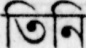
তিনি
